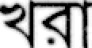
খরা
